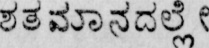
ಶತಮಾನದಲ್ಲೇ
